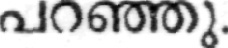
പറഞ്ഞു.
